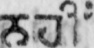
ਨਹੀਂ
